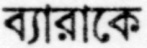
ব্যারাকে
